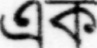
এক
